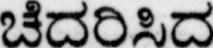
ಚೆದರಿಸಿದ
